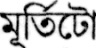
মূর্তিটো
